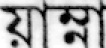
য়াম্না
